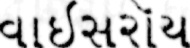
વાઇસરૉય
